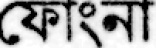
ফোংনা
